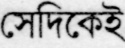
সেদিকেই
